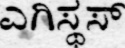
ಎಗಿಸ್ಥಸ್
